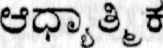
ಆಧ್ಯಾತ್ಮಿಕ
